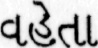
વહેતા
